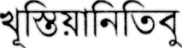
খূস্তিয়ানিতিবু
